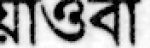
য়াওবা
